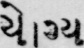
યોગ્ય
